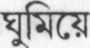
ঘুমিয়ে
